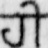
ਹੀ
